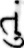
તું
